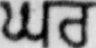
ਘਰ
